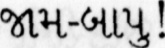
જામ-બાપુ!
